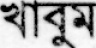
খাবুম
